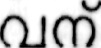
വന്
